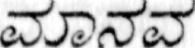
ಮಾನವ
